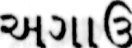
અગાઉ
